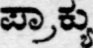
ಪ್ರಾಕ್ಯು
